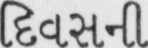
દિવસની
